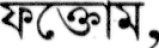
ফক্তোম,
